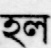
হল
